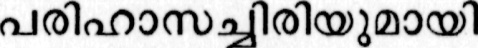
പരിഹാസച്ചിരിയുമായി
